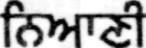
ਨਿਆਣੀ
